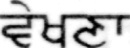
ਵੇਖਣਾ
